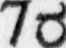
7ರ
